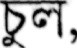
চুল,
